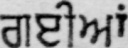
ਗਈਆਂ
